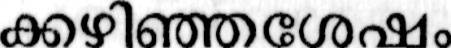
ക്കഴിഞ്ഞശേഷം
